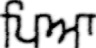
ਪਿਆ
